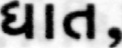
ધાત,
